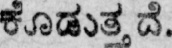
ಕೊಡುತ್ತದೆ.
